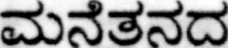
ಮನೆತನದ
